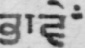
ਭਾਵੇਂ
